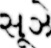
સૂઝે
